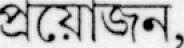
প্রয়োজন,
